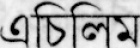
এচিলিম
